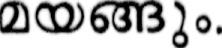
മയങ്ങും.
